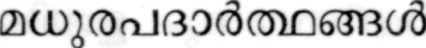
മധുരപദാര്‍ത്ഥങ്ങള്‍
